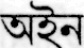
অইন
